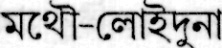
মথৌ-লোইদুনা
